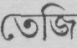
তেজি
